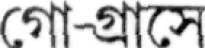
গো-গ্রাসে
